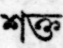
শক্ত
